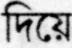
দিয়ে
